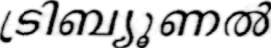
ട്രിബ്യൂണല്‍
